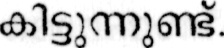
കിട്ടുന്നുണ്ട്.
